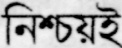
নিশ্চয়ই
